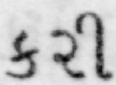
કરી
